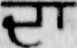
ਦਾ
